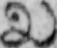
ಖ
